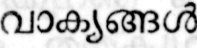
വാക്യങ്ങള്‍
